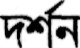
দর্শন
